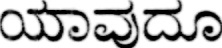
ಯಾವುದೂ
